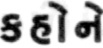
કહોને
